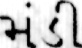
મંડી
